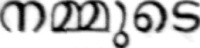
നമ്മുടെ
